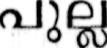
പുല്ല
